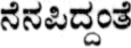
ನೆನಪಿದ್ದಂತೆ
